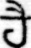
ਹੈ
